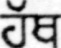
ਹੱਥ
